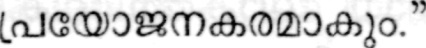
പ്രയോജനകരമാക്കും.”
